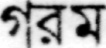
গরম
